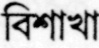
বিশাখা
